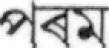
পৰম
